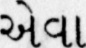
એવા
